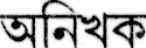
অনিখক
